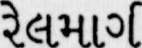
રેલમાર્ગ
